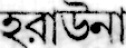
হরাউনা
